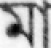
মা
